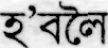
হ'বলৈ
